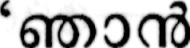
'ഞാന്‍
